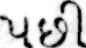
પછી
